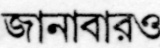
জানাবারও
